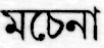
মচেনা
